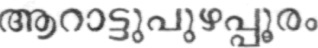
ആറാട്ടുപ്പൂരം
